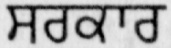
ਸਰਕਾਰ
